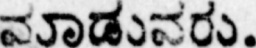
ಮಾಡುವರು.
